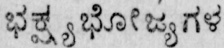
ಭಕ್ಷ್ಯಭೋಜ್ಯಗಳ
